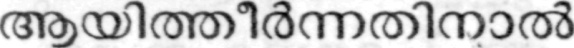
ആയിത്തീര്‍ന്നതിനാല്‍
